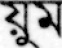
য়ুম
